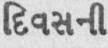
દિવસની
